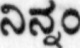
ನಿನ್ನಂ
